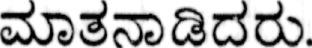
ಮಾತನಾಡಿದರು.
